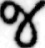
જ
